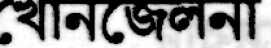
খোনজেলনা
